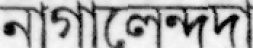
নাগালেন্দদা
